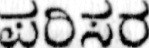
ಪರಿಸರ
